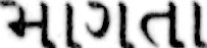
માગતા
